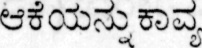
ಆಕೆಯನ್ನುಕಾವ್ಯ
